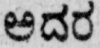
ಅದರ
